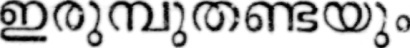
ഇരുമ്പുതണ്ടയും
